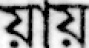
য়ায়
